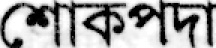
শোকপদা
